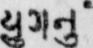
યુગનું
